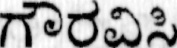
ಗೌರವಿಸಿ
